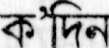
ক’দিন
